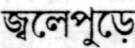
জ্বলেপুড়ে
